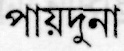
পায়দুনা
